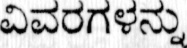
ವಿವರಗಳನ್ನು
